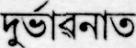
দুর্ভাৱনাত
